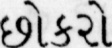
છોકરો
